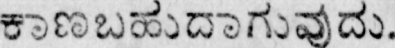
ಕಾಣಬಹುದಾಗುವುದು.
